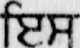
ਇਸ
